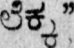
ಲೆಕ್ಕ”
